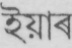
ইয়াৰ
